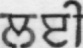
ਲਈ
